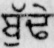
ਬੁੱਢੇ
